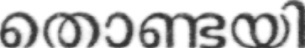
തൊണ്ടയി
